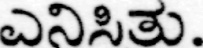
ಎನಿಸಿತು.
